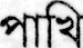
পাখি
